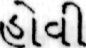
હોવી
